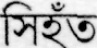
সিহঁত
